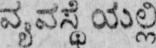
ವ್ಯವಸ್ಥೆಯಲ್ಲಿ
